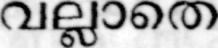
വല്ലാതെ
